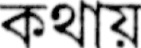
কথায়
